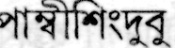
পাম্বীশিংদুবু
